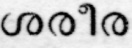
ശരീര
